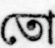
তো
